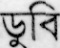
ডুবি
